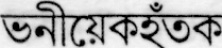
ভনীয়েকহঁতক
